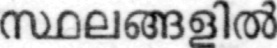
സ്ഥലങ്ങളില്‍
